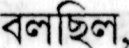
বলছিল,
